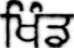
ਖਿੰਡ
